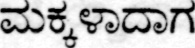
ಮಕ್ಕಳಾದಾಗ
